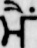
ਮੈਂ
